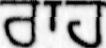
ਰਾਹ
